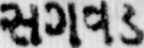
સગવડ
